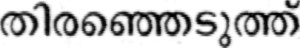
തിരഞ്ഞെടുത്ത്
